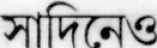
সাদিনেও
